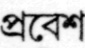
প্রবেশ
